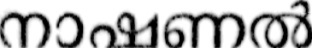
നാഷണല്‍
